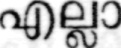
എല്ലാ
